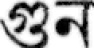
গুন
